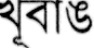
খূবাঙ
